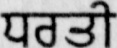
ਧਰਤੀ
